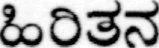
ಹಿರಿತನ
